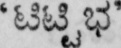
‘ಟಿಟ್ಟಿಭ’
